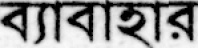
ব্যাবাহার
